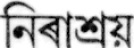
নিৰাশ্রয়
